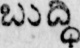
ಬುದ್ಧಿ
